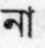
না
